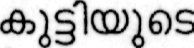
കുട്ടിയുടെ
